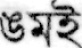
ঙমই
